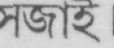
সজাই
